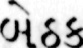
બેઠક
